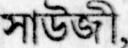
সাউজী
